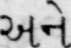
અને
